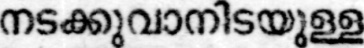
നടക്കുവാനിടയുള്ള
